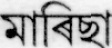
মাৰিছা
